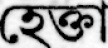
হেক্তা
